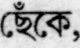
ছেঁকে,
